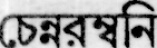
চেন্নরম্বনি
